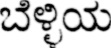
ಬೆಳ್ಳಿಯ
